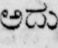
ಅದು
